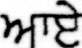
ਆਏ
